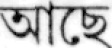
আছে
